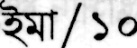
ইমা/১০
